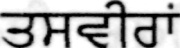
ਤਸਵੀਰਾਂ
